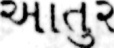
આતુર
